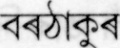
বৰঠাকুৰ
